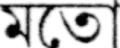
মতো
